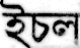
ইচল
